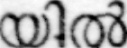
യില്‍
